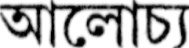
আলোচ্য
